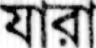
যারা
